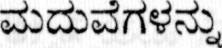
ಮದುವೆಗಳನ್ನು
